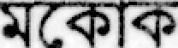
মকোক
